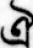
ঐ
